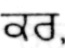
ਕਰ,
